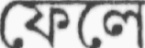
ফেলে
